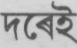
দৰেই
